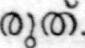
രുത്.
